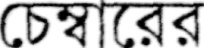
চেম্বারের
